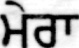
ਮੇਰਾ
